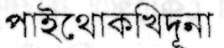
পাইথোকখিদূনা
